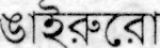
ঙাইরুরো
